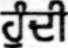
ਹੁੰਦੀ
